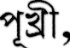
পূখ্রী,
